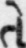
તે
